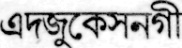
এদজুকেসনগী
